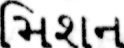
મિશન
